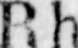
Rh
